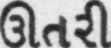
ઊતરી
